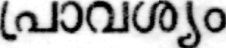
പ്രാവശ്യം
